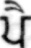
ਪੈ
